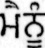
ਮੈਨੂੰ
